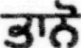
ਭਾਨੋ
